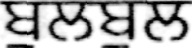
ਬੁਲਬੁਲ
